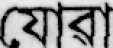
যোৱা
